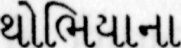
થોભિયાના
